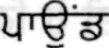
ਪਾਉਂਡ
